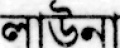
লাউনা
